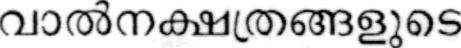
വാല്‍നക്ഷത്രങ്ങളുടെ
